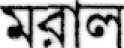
মরাল
